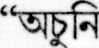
“অচুনি
